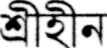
শ্রীহীন
